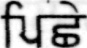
ਪਿਛੇ
